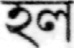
হল
